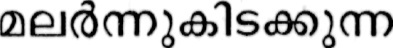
മലര്‍ന്നുകിടക്കുന്ന
